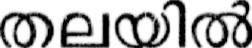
തലയില്‍
